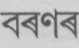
বৰণৰ
